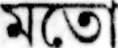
মতো
